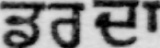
ਡਰਦਾ
